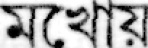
মখোয়
